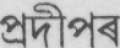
প্ৰদীপৰ
